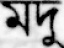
মদু
